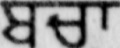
ਬਚਾ
